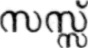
സസ്സ്
